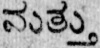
ಮತ್ತು
